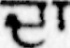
ਦਾ
